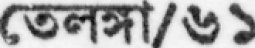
তেলঙ্গা/৬১
